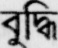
বুদ্ধি
